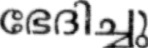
ഭേദിച്ചു
